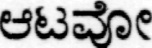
ಆಟವೋ
